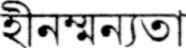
হীনম্মন্যতা
